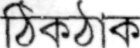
ঠিকঠাক
